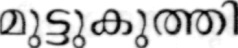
മുട്ടുകുത്തി
